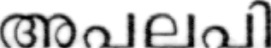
അപലപി
